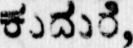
ಕುದುರೆ,
